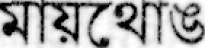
মায়থোঙ
